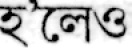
হ'লেও
